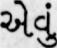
એવું
